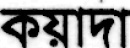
কয়াদা
